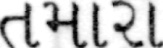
તમારા
